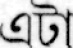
এটা
